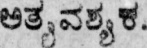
ಅತ್ಯವಶ್ಯಕ.
